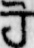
ਹੋ
